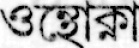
ওন্থোক্না
